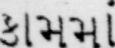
કામમાં
